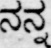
ನನ್ನ
